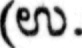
(ಉ.
